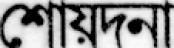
শোয়দনা
